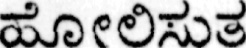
ಹೋಲಿಸುತ
